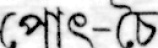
পোৎ-চৈ
